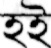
হই
